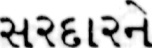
સરદારને
